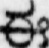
ಈ
